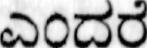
ಎಂದರೆ
